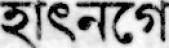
হাৎনগে
